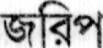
জরিপ
